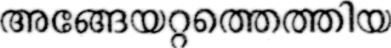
അങ്ങേയറ്റത്തെത്തിയ
